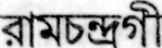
রামচন্দ্রগী
